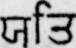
ਯਤਿ
